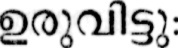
ഉരുവിട്ടു:
